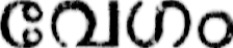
വേഗം
